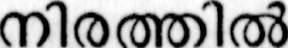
നിരത്തില്‍
